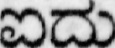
ಐದು
